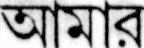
আমার
